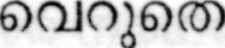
വെറുതെ
